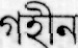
গহীন
